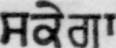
ਸਕੇਗਾ
